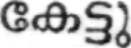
കേട്ടു
